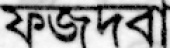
ফজদবা
